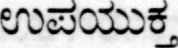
ಉಪಯುಕ್ತ
